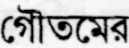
গৌতমের
